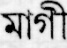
মাগী
